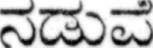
ನಡುವೆ
